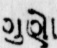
ગુણો
